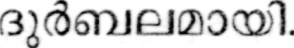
ദുര്‍ബലമായി.
